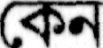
কেন
